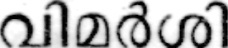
വിമര്‍ശി
